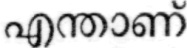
എന്താണ്
